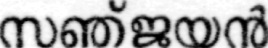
സഞ്ജയന്‍
